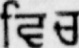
ਵਿਚ
